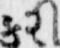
કરી
